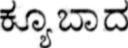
ಕ್ಯೂಬಾದ
